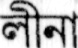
লীনা
